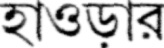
হাওড়ার
